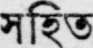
সহিত
